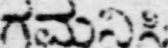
ಗಮನಿಸಿ
